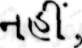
નહીં,
